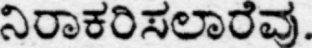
ನಿರಾಕರಿಸಲಾರೆವು.
